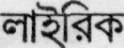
লাইরিক
